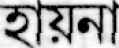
হায়না
